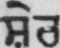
ਸ਼ੇਰ
